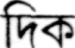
দিক
